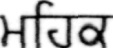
ਮਹਿਕ
